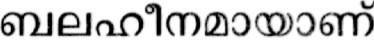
ബലഹീനമായാണ്
